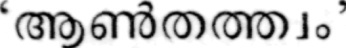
'ആണ്‍തത്ത്വം'
